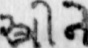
સ્ત્રીને
